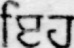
ਇਹ
